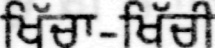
ਖਿੱਚਾ-ਖਿੱਚੀ
